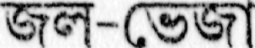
জল-ভেজা
